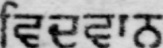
ਵਿਦਵਾਨ
